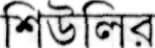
শিউলির
